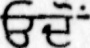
ਓਦੋਂ
